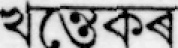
খন্তেকৰ
